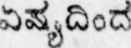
ಏಷ್ಯದಿಂದ
